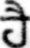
ਹੈ
